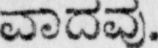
ವಾದವು.
